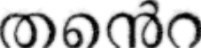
തന്റെ
